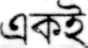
একই
